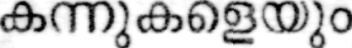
കന്നുകളെയും
